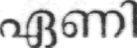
ഏണി
